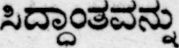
ಸಿದ್ಧಾಂತವನ್ನು
